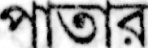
পাতার
